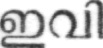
ഇവി
